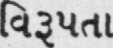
વિરૂપતા
